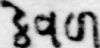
કેવળ
